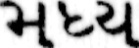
મધ્ય
